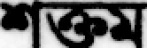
শক্তম
